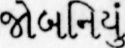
જોબનિયું
